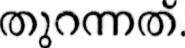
തുറന്നത്.
